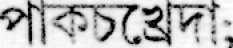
পাকচখ্রেদা,
